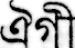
ঐগী
